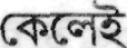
কেলেই
